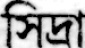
সিদ্রা
